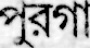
পুরগা
